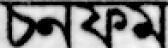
চনফম
